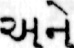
અને
